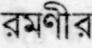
রমণীর
